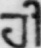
ਹੀ
